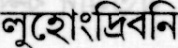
লুহোংদ্রিবনি
